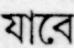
যাবে
